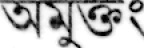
অমুক্তং
